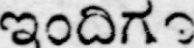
ಇಂದಿಗೂ
